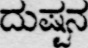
ದುಷ್ಟನ
